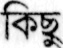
কিছু
